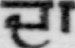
ਦਾ
